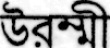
উরম্মী
